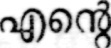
എന്റെ
